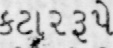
કટારરૂપે
